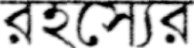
রহস্যের
